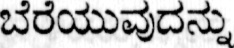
ಬೆರೆಯುವುದನ್ನು
